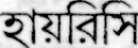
হায়রিসি
